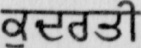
ਕੁਦਤਰੀ
